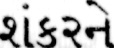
શંકરને
